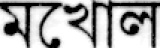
মখোল
